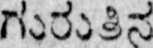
ಗುರುತಿನ
